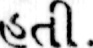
હતી.
